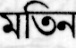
মতিন
